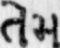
તેમ
